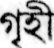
গৃহী
